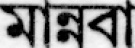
মান্নবা
